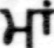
ਮਾਂ
